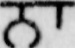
ਨਾ
